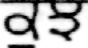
ਕੁਝ
